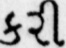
કરી
